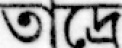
তাদ্রে
